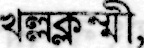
খল্লক্লম্মী,
